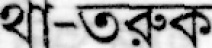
থা-তরুক
